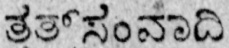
ತತ್‌ಸಂವಾದಿ
